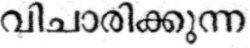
വിചാരിക്കുന്ന
